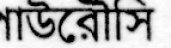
পাউরৌসি
